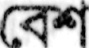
বেশ
